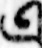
এ
